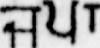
ਜਪਾ
